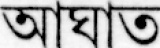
আঘাত
